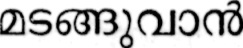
മടങ്ങുവാന്‍
